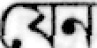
যেন
